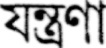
যন্ত্রণা
